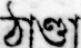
ঠাণ্ডা
